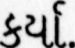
કર્યા.
